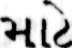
માટે
